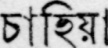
চাহিয়া
